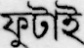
ফুটাই
